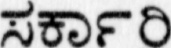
ಸರ್ಕಾರಿ
